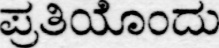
ಪ್ರತಿಯೊಂದು
